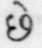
છે
